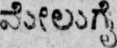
ಮೇಲುಗೈ
